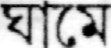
ঘামে
